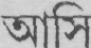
আসি
